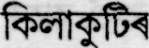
কিলাকুটিৰ
